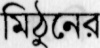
মিঠুনের
